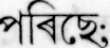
পৰিছে;
